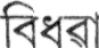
বিধৱা
